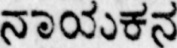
ನಾಯಕನ
